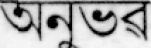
অনুভৱ
